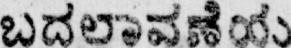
ಬದಲಾವಣೆಯ
